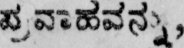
ಪ್ರವಾಹವನ್ನು,
